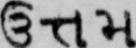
ઉત્તમ
